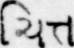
ચિત્ત
